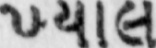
ખ્યાલ
